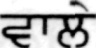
ਵਾਲੇ
